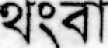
থংবা
